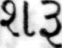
શરૂ
